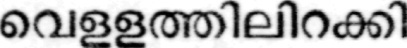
വെളളത്തിലിറക്കി
